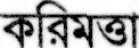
করিমত্তা
